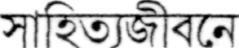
সাহিত্যজীবনে
